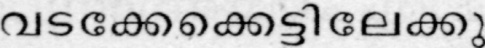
വടക്കേക്കെട്ടിലേക്കു
